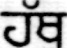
ਹੱਥ
